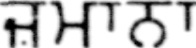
ਜ਼ਮਾਨਾ
